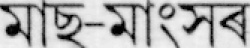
মাছ-মাংসৰ
